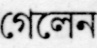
গেলেন
